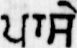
ਪਾਸੇ
